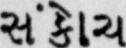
સંકોચ
